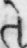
તે
